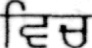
ਵਿਚ
